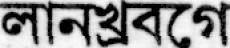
লানখ্রবগে
